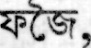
ফজৈ,
